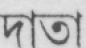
দাতা
